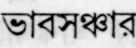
ভাবসঞ্চার
